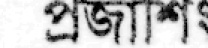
প্রজাশি
